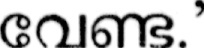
വേണ്ട.'
